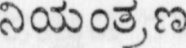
ನಿಯಂತ್ರಣ
